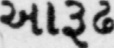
આરૂઢ
